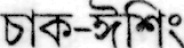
চাক-ঈশিং
